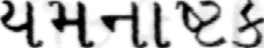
યમનાષ્ટક
